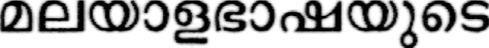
മലയാളഭാഷയുടെ
